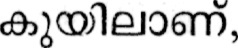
കുയിലാണ്,
